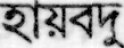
হায়বদু
